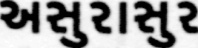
અસુરાસુર
